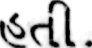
હતી.
